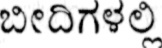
ಬೀದಿಗಳಲ್ಲಿ
